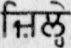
ਜ਼ਿਲ੍ਹੇ
